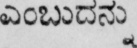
ಎಂಬುದನ್ನು
